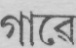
গাৱে
